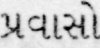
પ્રવાસો
